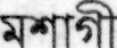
মশাগী
